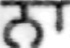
ਨਾ
